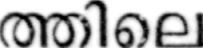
ത്തിലെ
